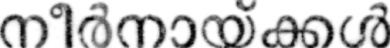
നീര്‍നായ്ക്കള്‍
